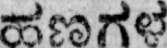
ಹಣಗಳ
